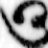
ও
